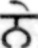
ਨੇ
